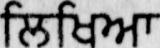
ਲਿਖਿਆ
